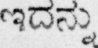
ಇದನ್ನು
